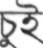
চুই
